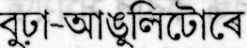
বুঢ়া-আঙুলিটোৰে
